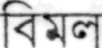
বিমল
